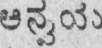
ಅನ್ವಯ
